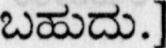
ಬಹುದು.]
